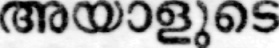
അയാളുടെ
